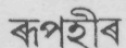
ৰূপহীৰ
